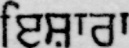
ਇਸ਼ਾਰਾ
